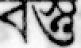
বস্তু
